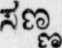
ಸಣ್ಣ
